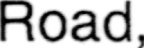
Road,
